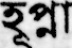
হূপ্না
